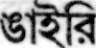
ঙাইরি
